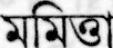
মমিত্তা
